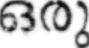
ഒരു
